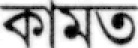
কামত
